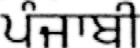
ਪੰਜਾਬੀ
